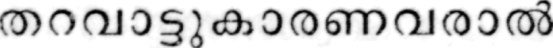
തറവാട്ടുകാരണവരാല്‍
